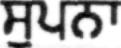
ਸੁਪਨਾ
